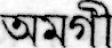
অমগী
